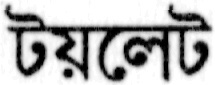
টয়লেট
